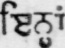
ਇਨ੍ਹਾਂ
